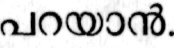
പറയാന്‍.
